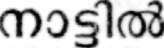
നാട്ടില്‍
